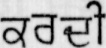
ਕਰਦੀ
